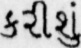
કરીશું
